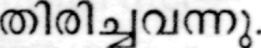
തിരിച്ചവന്നു.
